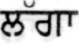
ਲੱਗਾ
